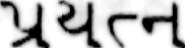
પ્રયત્ન
